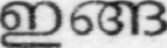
ഇങ്ങ
